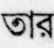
তার
